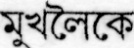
মুখলৈকে
